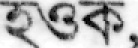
হওক,
